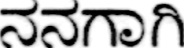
ನನಗಾಗಿ
